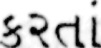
કરતાં
